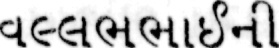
વલ્લભભાઈની
